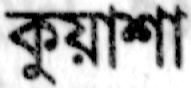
কুয়াশা
